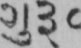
ગુરૂ.
